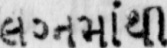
લગ્નમાંથી
